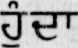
ਹੁੰਦਾ
